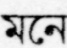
মনে
